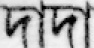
দাদা
